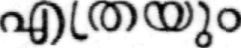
എത്രയും
